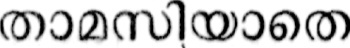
താമസിയാതെ
